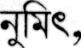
নুমিৎ,
